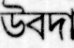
উবদা
